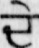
ਦੇ
